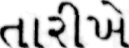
તારીખે
